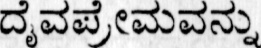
ದೈವಪ್ರೇಮವನ್ನು
